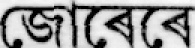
জোৰেৰে
